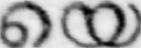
യെ
